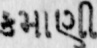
કમાણી
